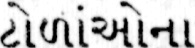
ટોળાંઓના
